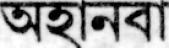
অহানবা
